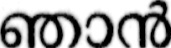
ഞാന്‍
